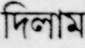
দিলাম
